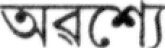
অৱশ্যে
